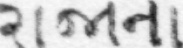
રાજાના
